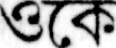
ওকে
